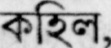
কহিল,
